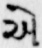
એ
